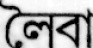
লৈবা
